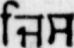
ਜਿਸ
